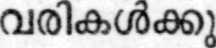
വരികള്‍ക്കു
